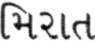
મિરાત
